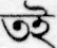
তই
